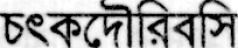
চৎকদৌরিবসি
